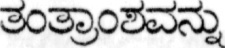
ತಂತ್ರಾಂಶವನ್ನು
